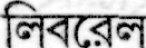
লিবরেল
